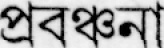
প্রবঞ্চনা
